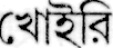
খোইরি
